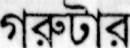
গরুটার
